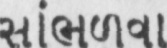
સાંભળવા
